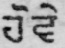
ਹੋਵੇ
